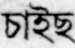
চাইছ
